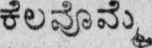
ಕೆಲವೊಮ್ಮೆ
